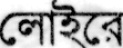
লোইরে
